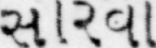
સારવા
